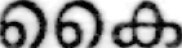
കൈ
